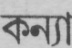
কন্যা
